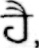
ਹੈ,
